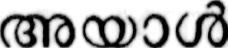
അയാള്‍
